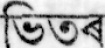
ভিতৰ
